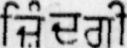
ਜ਼ਿੰਦਗੀ
